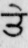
ਤੇ
